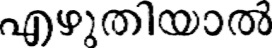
എഴുതിയാല്‍
